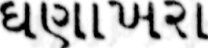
ઘણાખરા
